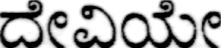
ದೇವಿಯೇ
